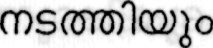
നടത്തിയും
